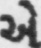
એ
